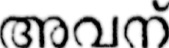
അവന്
